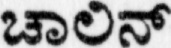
ಚಾಲಿನ್
